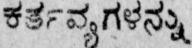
ಕರ್ತವ್ಯಗಳನ್ನು
